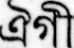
ঐগী
